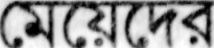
মেয়েদের
